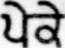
ਪੇਕੇ
